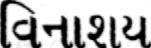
વિનાશય
